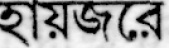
হায়জরে
